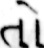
તો
